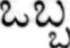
ಒಬ್ಬ
